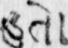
હતો
